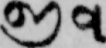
જીવ
